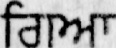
ਗਿਆ
